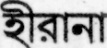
হীরানা
